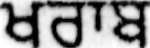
ਖਰਾਬ
